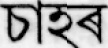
চাহৰ
